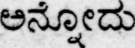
ಅನ್ನೋದು
